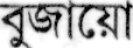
বুজায়ো
